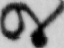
જ
